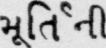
મૂર્તિની
